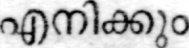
എനിക്കും
